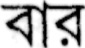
বার
